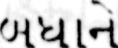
બધાને
